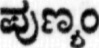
ಪುಣ್ಯಂ
